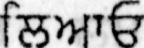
ਲਿਆਓ
